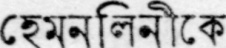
হেমনলিনীকে
